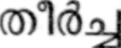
തീര്‍ച്ച
